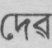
দেৱ
